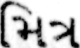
મિત્ર
